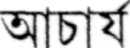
আচার্য
